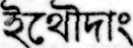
ইথৌদাং
